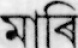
মাৰি
